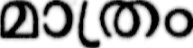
മാത്രം
